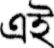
এই
